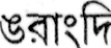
ঙরাংদি
